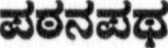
ಪಠನಪಥ
